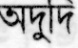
অদুদি
